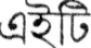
এইটি
